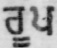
ਰੂਪ
